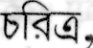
চরিত্র,
